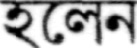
হলেন
